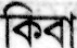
কিবা
